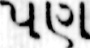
પણ
